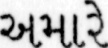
અમારે
